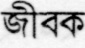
জীবক
